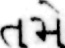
તમે
